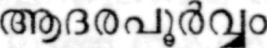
ആദരപൂര്‍വ്വം
